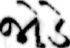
જોડે
